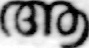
ആ
